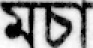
মচা
